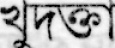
খুদক্তা
